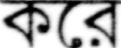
করে
